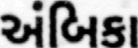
અંબિકા
